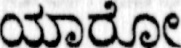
ಯಾರೋ
